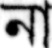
না
